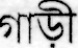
গাড়ী
